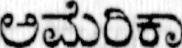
ಅಮೆರಿಕಾ
